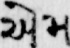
એમ
